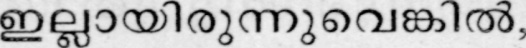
ഇല്ലായിരുന്നുവെങ്കില്‍,
